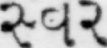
સ્વર
